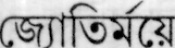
জ্যোতির্ময়ে
